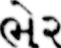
ભેર
